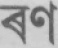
ৰণ
